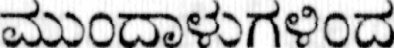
ಮುಂದಾಳುಗಳಿಂದ
